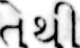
તેથી
